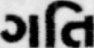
ગતિ
